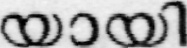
യായി
